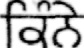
ਕਿੰਨੇ
